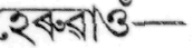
হেৰুৱাওঁ-
